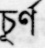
চূর্ণ
